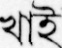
খাই
